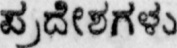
ಪ್ರದೇಶಗಳು
